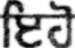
ਇਹੋ
